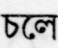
চলে
